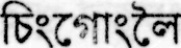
চিংগোংলৈ
